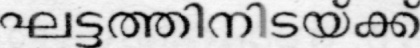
ഘട്ടത്തിനിടയ്ക്ക്
